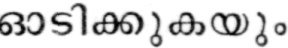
ഓടിക്കുകയും
